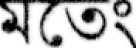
মতেং
